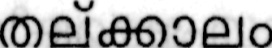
തല്ക്കാലം
